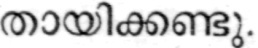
തായിക്കണ്ടു.
